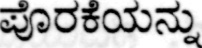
ಪೊರಕೆಯನ್ನು
